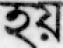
হয়
